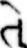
તે
